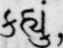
કહ્યું,
